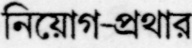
নিয়োগ-প্রথার
